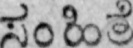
ಸಂಹಿತೆ
